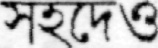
সহদেও
